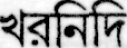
খরনিদি
